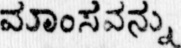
ಮಾಂಸವನ್ನು
